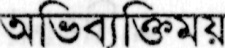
অভিব্যক্তিময়
